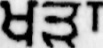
ਖੜਾ
